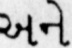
અને
